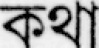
কথা
